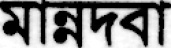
মান্নদবা
